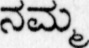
ನಮ್ಮ
